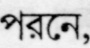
পরনে,
